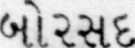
બોરસદ
